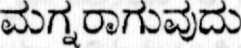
ಮಗ್ನರಾಗುವುದು
